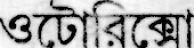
ওটোরিক্সো
